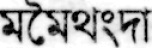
মমৈথংদা
